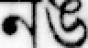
নঙ
